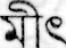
মীৎ
